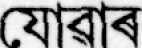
যোৱাৰ
